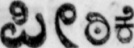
ಪೀಠಿಕೆ
